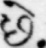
છે.
